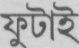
ফুটাই
